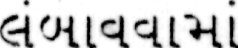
લંબાવવામાં
